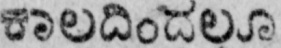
ಕಾಲದಿಂದಲೂ
